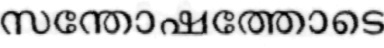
സന്തോഷത്തോടെ
